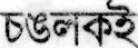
চঙলকই
